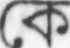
কে
